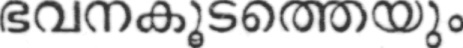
ഭവനകൂടത്തെയും
